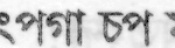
পগা চপ
